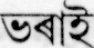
ভৰাই
